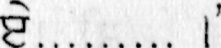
ਏ..............।'
